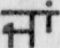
ਜਾਂ
